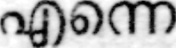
എന്നെ
